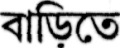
বাড়িতে
